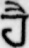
ਹੈ
